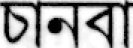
চানবা
